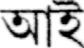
আই
